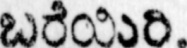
ಬರೆಯಿರಿ.
